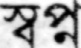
স্বপ্ন
